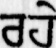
ਰਹੇ
